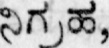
ನಿಗ್ರಹ,
